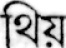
থিয়
